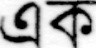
এক
